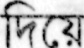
দিয়ে
